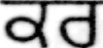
ਕਰ
